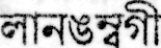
লানঙম্বগী
